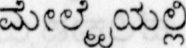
ಮೇಲ್ಮೈಯಲ್ಲಿ
